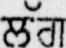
ਲੱਗ
